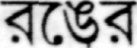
রঙের
